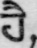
ਹੈ,
